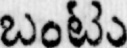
ಬಂಟು
